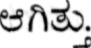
ಆಗಿತ್ತು.
